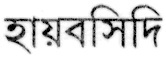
হায়বসিদি
